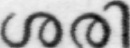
ശരി
